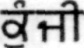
ਕੁੰਜੀ
